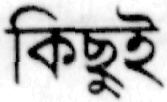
কিছুই
